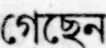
গেছেন
